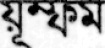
য়ুম্ফম
